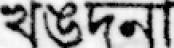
খঙদনা
